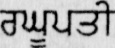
ਰਘੂਪਤੀ
